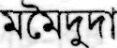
মমৈদুদা
